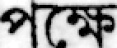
পক্ষে
